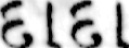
દાદા
